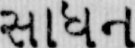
જ્ઞાન
